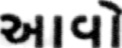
આવો
